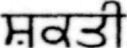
ਸ਼ਕਤੀ
